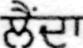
ਲੈਂਦਾ
